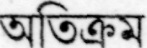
অতিক্রম
